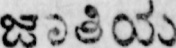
ಜಾತಿಯ
